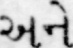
અને
